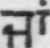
ਜਾਂ
